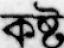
কষ্ট
